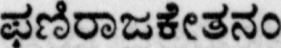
ಫಣಿರಾಜಕೇತನಂ
